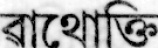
ৱাথোক্তি
